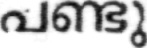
പണ്ടു
